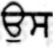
ਉਸ
